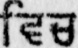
ਵਿਚ
